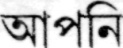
আপনি
